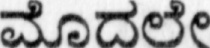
ಮೊದಲೇ
